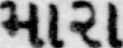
મારા
